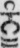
ਨੂੰ
